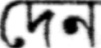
দেন
